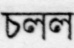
চলল
